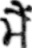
ਮੈਂ
